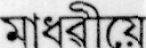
মাধৱীয়ে
